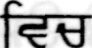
ਵਿਚ
